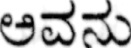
ಅವನು
